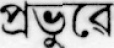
প্রভুৱে
